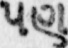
પણ
